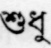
শুধু
